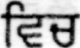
ਵਿਚ
